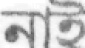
নাই
